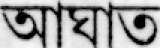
আঘাত
